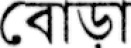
বোড়া
